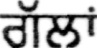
ਗੱਲਾਂ
